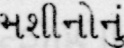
મશીનોનું
